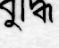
বুদ্ধি
